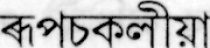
ৰূপচকলীয়া
